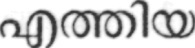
എത്തിയ
